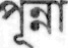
পূন্না
